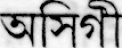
অসিগী
